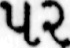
પર
